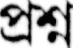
প্রশ্ন
